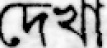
দেখা
